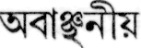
অবাঞ্ছনীয়
